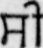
ਸੀ
